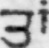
ਤਾਂ
